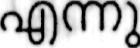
എന്നു
